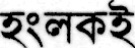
হংলকই
